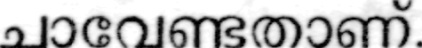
ചാവേണ്ടതാണ്.
